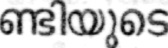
ണ്ടിയുടെ
